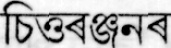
চিত্তৰঞ্জনৰ
